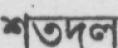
শতদল
